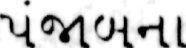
પંજાબના
